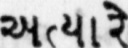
અત્યારે
